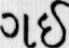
ગઈ
